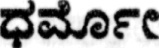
ಧರ್ಮೋ
